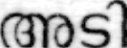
അടി
